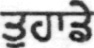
ਤੁਹਾਡੇ
